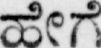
ಹೇಗೆ
